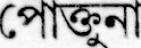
পোক্তুনা
